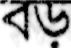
বড়
